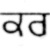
ਕਰ
